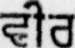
ਵੀਰ
